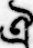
ঐ
